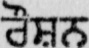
ਰੌਸ਼ਨ
